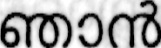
ഞാന്‍
